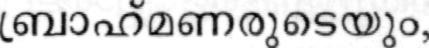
ബ്രാഹ്മണരുടെയും,
